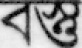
বস্তু
